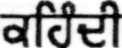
ਕਹਿੰਦੀ
